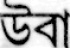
উবা
